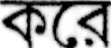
করে
